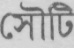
সৌটি
